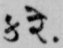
કરે.
